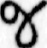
જ
